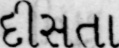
દીસતા
